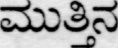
ಮುತ್ತಿನ
